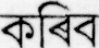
কৰিব
